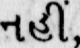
નહીં,
